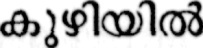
കുഴിയില്‍
